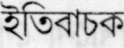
ইতিবাচক
